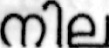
നില
